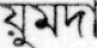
য়ুমদা
